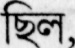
ছিল,
